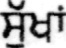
ਸੁੱਖਾਂ
